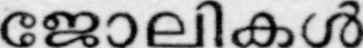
ജോലികള്‍
